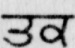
ਤਕ
